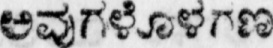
ಅವುಗಳೊಳಗಣ
